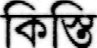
কিস্তি
